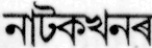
নাটকখনৰ
